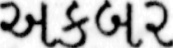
અકબર
